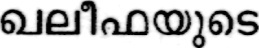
ഖലീഫയുടെ
